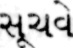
સૂચવે
